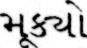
મૂકયો
